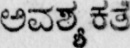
ಅವಶ್ಯಕತೆ
